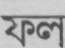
ফল
